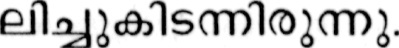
ലിച്ചുകിടന്നിരുന്നു.
